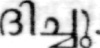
ദിച്ചു.
